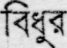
বিধুর
